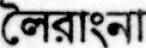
লৈরাংনা
